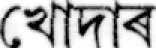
খোদাৰ
